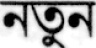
নতুন
